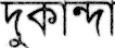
দুকান্দা
